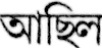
আছিল
